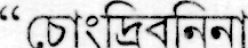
“চোংদ্রিবনিনা
